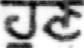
ਹੁਣ
